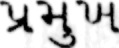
પ્રમુખ
